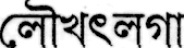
লৌখৎলগা
